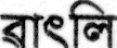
ৱাৎলি
